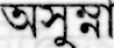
অসুম্না
